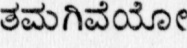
ತಮಗಿವೆಯೋ
